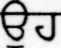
ਉਹ
